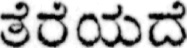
ತೆರೆಯದೆ
